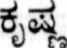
ಕೃಷ್ಣ
